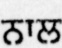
ਨਾਲ
